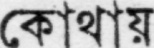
কোথায়
